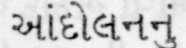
આંદોલનનું
